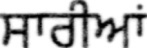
ਸਾਰੀਆਂ
